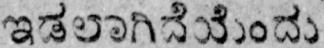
ಇಡಲಾಗಿದೆಯೆಂದು
